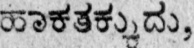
ಹಾಕತಕ್ಕುದು,
